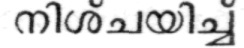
നിശ്ചയിച്ച്
